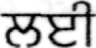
ਲਈ
